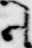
ને
